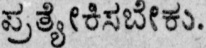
ಪ್ರತ್ಯೇಕಿಸಬೇಕು.
